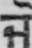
ਜੋ
